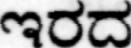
ಇರದ
